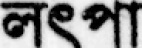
লৎপা
